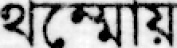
থম্মোয়
